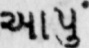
આપું
